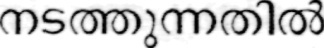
നടത്തുന്നതില്‍
